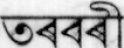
তৰবৰী
